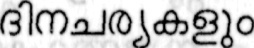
ദിനചര്യകളും
